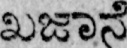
ಖಜಾನೆ
